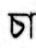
চা
